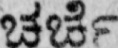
ಚರ್ಚೆ
